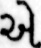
એ
